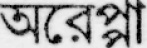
অরেপ্পা
